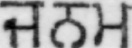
ਜਨਮ
